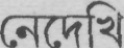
নেদেখি
